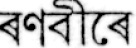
ৰণবীৰে
